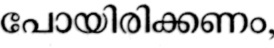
പോയിരിക്കണം,
